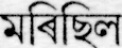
মৰিছিল
